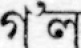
গ'ল
